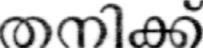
തനിക്ക്
